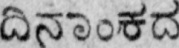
ದಿನಾಂಕದ
